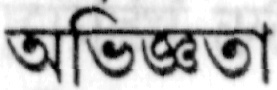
অভিজ্ঞতা
